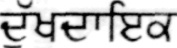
ਦੁੱਖਦਾਇਕ
